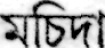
মচিদা
